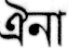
ঐনা
